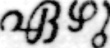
ഏഴു
